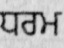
ਧਰਮ
